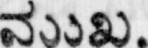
ಮುಖ.
